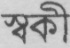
স্বকী
